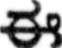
ಈ
